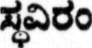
ಸ್ಥವಿರಂ
